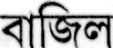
বাজিল
